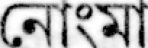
নোংমা
